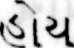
હોય
